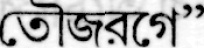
তৌজরগে”
